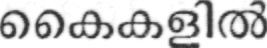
കൈകളില്‍
